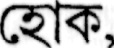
হোক,
